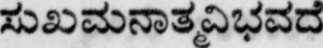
ಸುಖಮನಾತ್ಮವಿಭವದೆ
